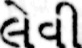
લેવી
